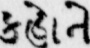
કહોને
